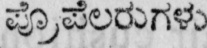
ಪ್ರೊಪೆಲರುಗಳು
